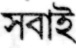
সবাই
